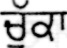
ਚੁੱਕਾ
